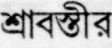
শ্রাবস্তীর
